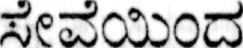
ಸೇವೆಯಿಂದ
